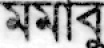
মমাবু
